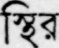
স্থির
